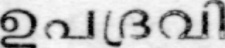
ഉപദ്രവി
